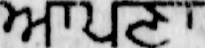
ਆਪਣਾ
